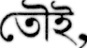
তৌই,
